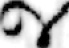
જ
